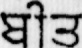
ਬੀਤ
